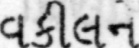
વકીલને
